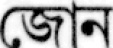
জোন
